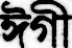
ঈগী
